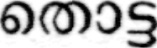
തൊട്ട
